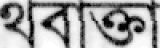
থবাক্তা
